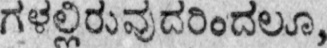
ಗಳಲ್ಲಿರುವುದರಿಂದಲೂ,
